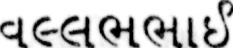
વલ્લભભાઈ
